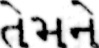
તેમને
